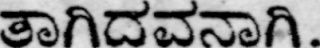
ತಾಗಿದವನಾಗಿ.
